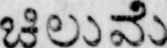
ಚಿಲುಮೆ
